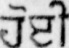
ਹੋਈ
